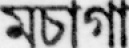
মচাগা
